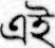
এই
